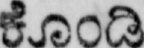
ಕೊಂಡಿ
